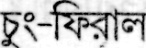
চুং-ফিরাল
